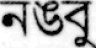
নঙবু
